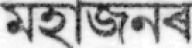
মহাজনৰ
